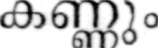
കണ്ണും
